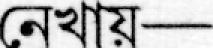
নেখায়-
